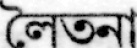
লৈতনা
